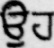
ਉਹ
